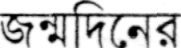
জন্মদিনের
